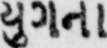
યુગના
